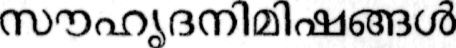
സൌഹൃദനിമിഷങ്ങള്‍
